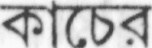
কাচের
